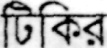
টিকির
